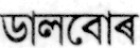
ডালবোৰ
